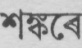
শঙ্কৰে
